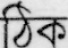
ঠিক
